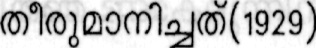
തീരുമാനിച്ചത്(1929)
